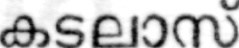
കടലാസ്
